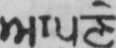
ਆਪਣੇ
